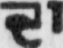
ਦਾ
